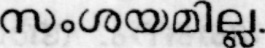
സംശയമില്ല.
